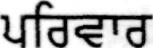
ਪਰਿਵਾਰ
